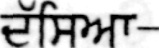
ਦੱਸਿਆ-
